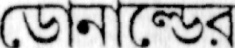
ডোনাল্ডের
